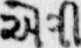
એવી
